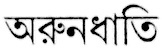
অরুনধাতি
